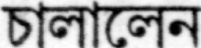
চালালেন
